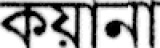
কয়ানা
